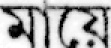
মায়ে
